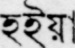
হইয়া
